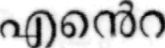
എന്റെ
